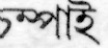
চম্পাই
